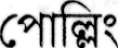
পোল্লিং
